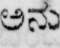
ಅನು
